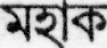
মহাক
